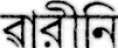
ৱারীনি
